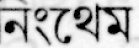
নিংথেম
